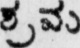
ಶ್ರಮ
